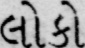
લોકો
